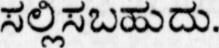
ಸಲ್ಲಿಸಬಹುದು.
